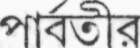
পার্বতীর
